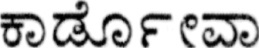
ಕಾರ್ಡೋವಾ
